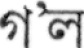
গ'ল
